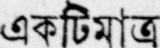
একটিমাত্র
